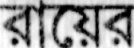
রায়ের
